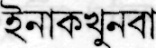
ইনাকখুনবা
